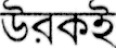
উরকই
